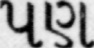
પણ
